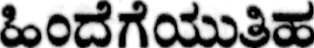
ಹಿಂದೆಗೆಯುತಿಹ
